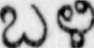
ಬಳಿ
